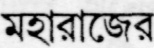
মহারাজের
